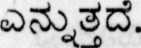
ಎನ್ನುತ್ತದೆ.
